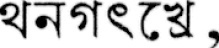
থনগৎখ্রে,
